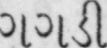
ગગડી
